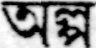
অল্প
